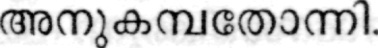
അനുകമ്പതോന്നി.
